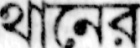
থানের
